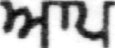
ਆਪ
